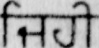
ਜਿਹੀ
